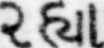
રહ્યા
